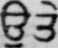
ਉਤੇ
